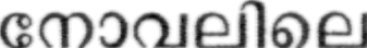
നോവലിലെ
